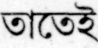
তাতেই
